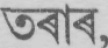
তৰাৰ,
